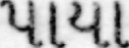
પાયા
